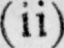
(ii)
